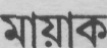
মায়াক
